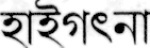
হাইগৎনা
